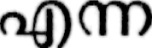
എന്ന
